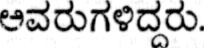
ಅವರುಗಳಿದ್ದರು.
